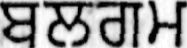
ਬਲਗਮ
